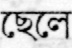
ছেলে
